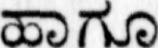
ಹಾಗೂ
